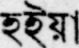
হইয়া
